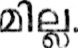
മില്ല.
